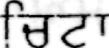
ਚਿਟਾ
